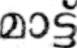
മാട്ട്
